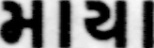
માયા
